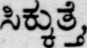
ಸಿಕ್ಕುತ್ತೆ,
